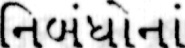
નિબંધોનાં
